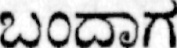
ಬಂದಾಗ
